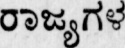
ರಾಜ್ಯಗಳ
